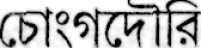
চোংগদৌরি
